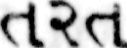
તરત
